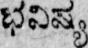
ಭವಿಷ್ಯ
